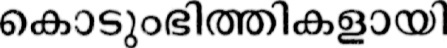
കൊടുംഭിത്തികളായി
